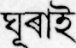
ঘূৰাই
